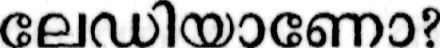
ലേഡിയാണോ?
